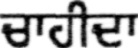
ਚਾਹੀਦਾ
